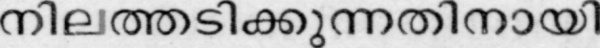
നിലത്തടിക്കുന്നതിനായി
